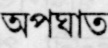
অপঘাত
